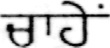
ਚਾਹੇਂ
